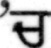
'ਚ
